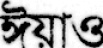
ঈয়াও
